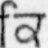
ਕਿ
